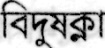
বিদুষক্না
